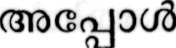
അപ്പോള്‍
